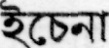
ইচেনা
